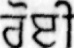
ਰੋਈ
